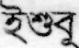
ইশুবু
